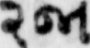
રજા
